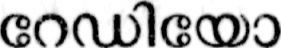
റേഡിയോ
